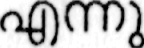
എന്നു
